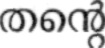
തന്റെ
